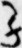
કે
